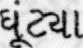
ઘુંટ્યા
